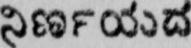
ನಿರ್ಣಯದ
